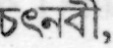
চৎনবী,
